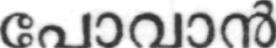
പോവാന്‍
